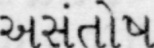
અસંતોષ
